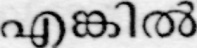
എങ്കില്‍
